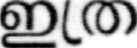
ഇത്ര
